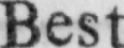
Best
